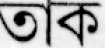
তাক
